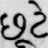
છૂટે
